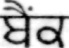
ਬੈਂਕ
